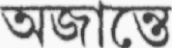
অজান্তে
